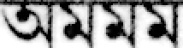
অমমম
